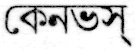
কেনভস্
